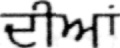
ਦੀਆਂ
